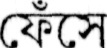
ফেঁসে
